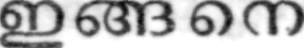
ഇങ്ങനെ
